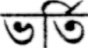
ভর্তি
